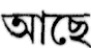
আছে
